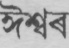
ঈশ্বৰ
